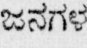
ಜನಗಳ
